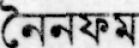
নৈনফম
